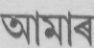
আমাৰ
